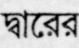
দ্বারের
